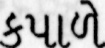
કપાળે
